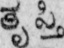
ತೃಪ್ತಿ
